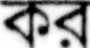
কর
